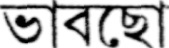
ভাবছো
